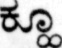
ಕ್ಹೂ
